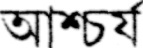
আশ্চর্য
